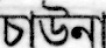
চাউনা
